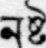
নষ্ট
